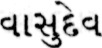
વાસુદેવ
